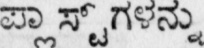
ಪ್ಲಾಸ್ಟ್‌ಗಳನ್ನು
